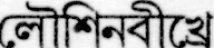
লৌশিনবীখ্রে
